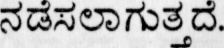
ನಡೆಸಲಾಗುತ್ತದೆ.
